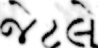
જેટલે
